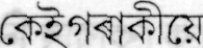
কেইগৰাকীয়ে
